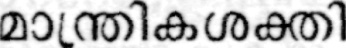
മാന്ത്രികശക്തി
